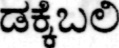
ಡಕ್ಕೆಬಲಿ
